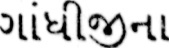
ગાંધીજીના
